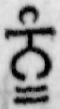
ਨੂੰ
